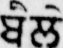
ਬੈਲੇ
